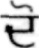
ਦੋ
